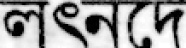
লৎনদে
